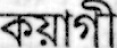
কয়াগী
